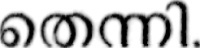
തെന്നി.
